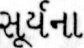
સૂર્યના
